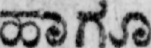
ಹಾಗೂ
